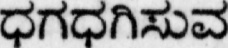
ಧಗಧಗಿಸುವ
